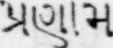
પ્રણામ
